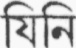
যিনি
